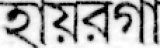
হায়রগা
